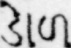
ડોળ
